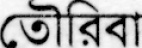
তৌরিবা
